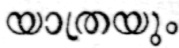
യാത്രയും
